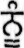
ਨੂੰ
